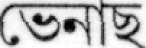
ভেনাছ
